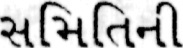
સમિતિની
